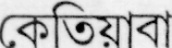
কেতিয়াবা
